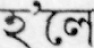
হ'লে
